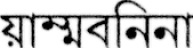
য়াম্মবনিনা
